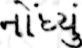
નોંધ્યું
